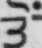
ਤੋਂ
